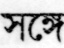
সঙ্গে
